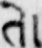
તો
